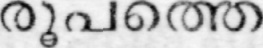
രൂപത്തെ
